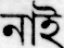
নাই
